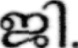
ജി.
